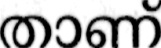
താണ്
